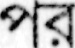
পর
